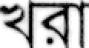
খরা
